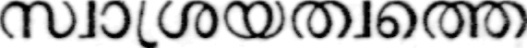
സ്വാശ്രയത്വത്തെ
